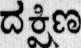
ದಕ್ಷಿಣ
